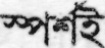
স্পৰ্শই
